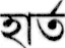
হার্ত
